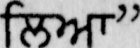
ਲਿਆ''
